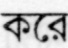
করে
